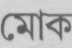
মোক
